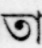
তা
